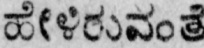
ಹೇಳಿರುವಂತೆ
